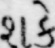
શકે
